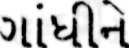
ગાંધીને
